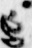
હું
